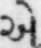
એ
